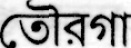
তৌরগা
